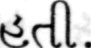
હતી.
